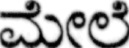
ಮೇಲೆ
